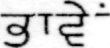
ਭਾਵੇਂ
